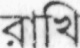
রাখি
